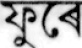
ফুৰে
